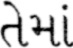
તેમાં
